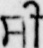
ਸੀ
